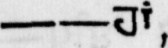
-------ਹਾਂ,
